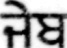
ਜੇਬ
